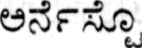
ಅರ್ನೆಸ್ಟೊ
